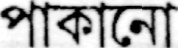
পাকানো
